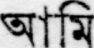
আমি
